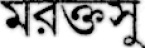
মরক্তসু
